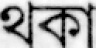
থকা
